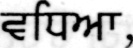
ਵਧਿਆ,
